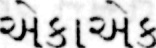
એકાએક
